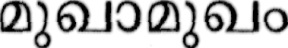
മുഖാമുഖം
